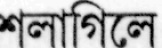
শলাগিলে
